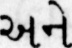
અને
